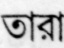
তারা
